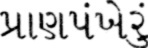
પ્રાણપંખેરું
